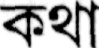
কথা
